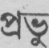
প্ৰভু
